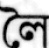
লৈ
